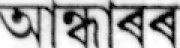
আন্ধাৰৰ
